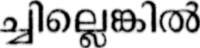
ച്ചില്ലെങ്കില്‍
